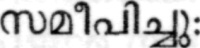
സമീപിച്ചു:
